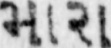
મારા
